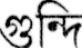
গুন্দি
